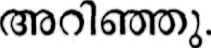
അറിഞ്ഞു.
